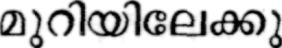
മുറിയിലേക്കു
